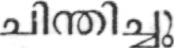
ചിന്തിച്ചു
